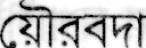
য়ৌরবদা
